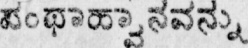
ಪಂಥಾಹ್ವಾನವನ್ನು
